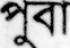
পুবা
